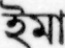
ইমা
